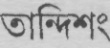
তান্দিশং
